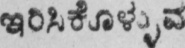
ಇರಿಸಿಕೊಳ್ಳುವ
